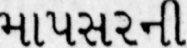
માપસરની
